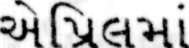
એપ્રિલમાં
